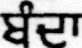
ਬੰਦਾ
